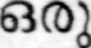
ഒരു
